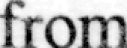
from
